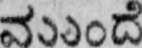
ಮುಂದೆ
